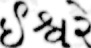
ઈશ્વરે
